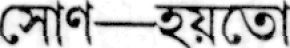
সোণ-হয়তো
